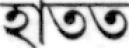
হাতত
